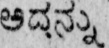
ಅದನ್ನು
